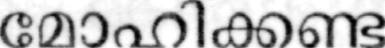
മോഹിക്കണ്ട
